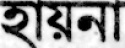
হায়না
